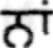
ਨਾਂ
